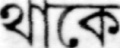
থাকে
